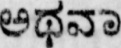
ಅಥವಾ
